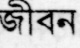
জীবন
